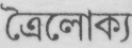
ত্ৰৈলোক্য
